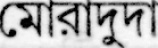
মোরাদুদা
